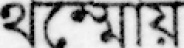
থম্মোয়
